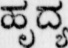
ಹೃದ್ಯ
